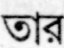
তার
